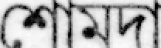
শোমদা
